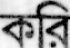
করি
